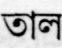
তাল
